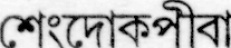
শেংদোকপীবা
